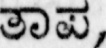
ತಾಪ,
